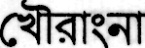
খৌরাংনা
